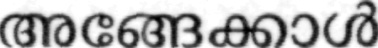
അങ്ങേക്കാള്‍
